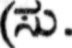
(ಸು.
